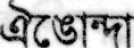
ঐঙোন্দা
